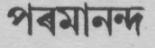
পৰমানন্দ
